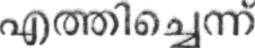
എത്തിച്ചെന്ന്
